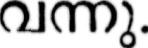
വന്നു.
